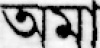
অমা
